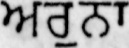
ਅਰੁਨਾ
